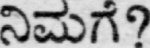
ನಿಮಗೆ?
